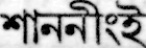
শাননীংই
